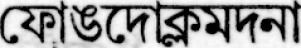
ফোঙদোক্লমদনা
